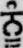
ਨੂੰ
